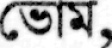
ভোম,
